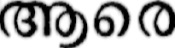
ആരെ
